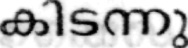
കിടന്നു
